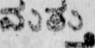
ಮತ್ತು
